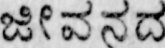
ಜೀವನದ
